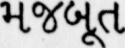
મજબૂત
